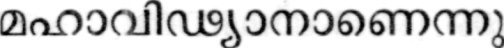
മഹാവിഢ്യാനാണെന്നു
